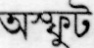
অস্ফুট
